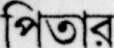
পিতার
